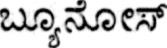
ಬ್ಯೂನೋಸ್
